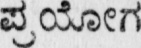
ಪ್ರಯೋಗ
